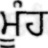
ਮੂੰਹ
